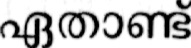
ഏതാണ്ട്
